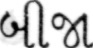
બીજા
